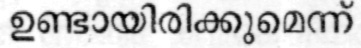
ഉണ്ടായിരിക്കുമെന്ന്
